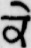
ਕੇ
